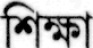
শিক্ষা
